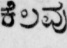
ಕೆಲವು
